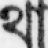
থা
